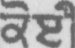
ਕੋਈ
